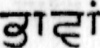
ਭਾਵਾਂ
